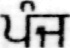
ਪੰਜ
